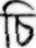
চি
